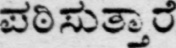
ಪಠಿಸುತ್ತಾರೆ
